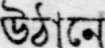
উঠানে
